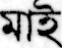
মাই
